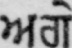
ਅਗੇ
